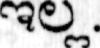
ಇಲ್ಲ.
